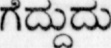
ಗೆದ್ದುದು
